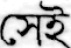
সেই
